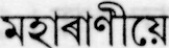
মহাৰাণীয়ে
